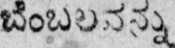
ಬೆಂಬಲವನ್ನು
